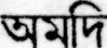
অমদি
